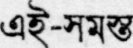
এই-সমস্ত
